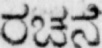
ರಚನೆ
